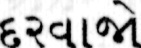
દરવાજો
